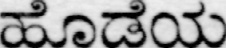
ಹೊಡೆಯ
